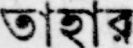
তাহার
